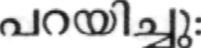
പറയിച്ചു:
